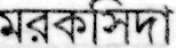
মরকসিদা
